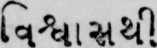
વિશ્વાસથી
